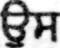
ਉਸ
